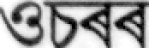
ওচৰৰ
